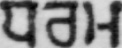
ਧਰਮ
